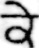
ਕੇ
